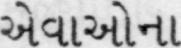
એવાઓના
